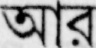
আর
